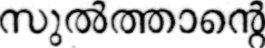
സുല്‍ത്താന്റെ
